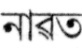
নাৱত
